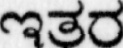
ಇತರ
